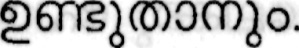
ഉണ്ടുതാനും.
